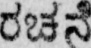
ರಚನೆ
